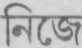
নিজে
